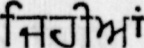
ਜਿਹੀਆਂ
